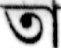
তা
